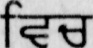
ਵਿਚ
